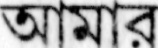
আমার
